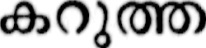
കറുത്ത
